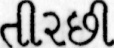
તીરછી
